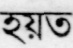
হয়ত
